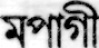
মপাগী
